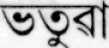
ভতুৱা
